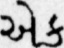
એક
